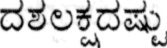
ದಶಲಕ್ಷದಷ್ಟು
